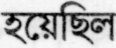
হয়েছিল
